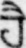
ਹੈ
